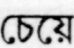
চেয়ে
